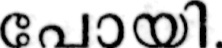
പോയി.
